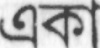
একা
